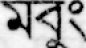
মবুং
